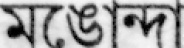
মঙোন্দা
